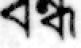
বন্ধ
